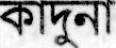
কাদুনা
